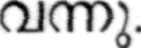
വന്നു.
